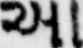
આ
